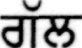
ਗੱਲ
